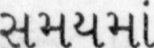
સમયમાં
